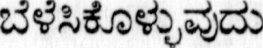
ಬೆಳೆಸಿಕೊಳ್ಳುವುದು
